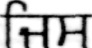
ਜਿਸ
